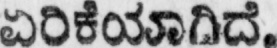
ಏರಿಕೆಯಾಗಿದೆ.
